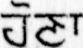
ਹੋਣਾ
